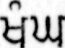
ਖੰਘ
